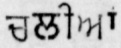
ਚਲੀਆਂ
